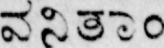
ವನಿತಾಂ
